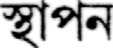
স্থাপন
